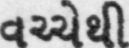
વચ્ચેથી
